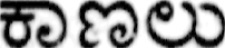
ಕಾಣಲು
